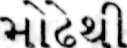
મોઢેથી
